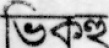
ভিকহু
